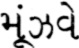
મૂંઝવે
